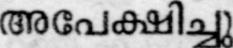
അപേക്ഷിച്ചു
